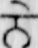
ਨੇ
